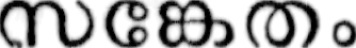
സങ്കേതം
